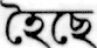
হৈছে
